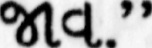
જાવ."
